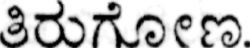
ತಿರುಗೋಣ.
